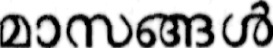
മാസങ്ങള്‍
